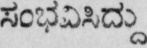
ಸಂಭವಿಸಿದ್ದು
